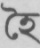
হৈ
